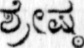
ಶ್ರೇಷ್ಠ
